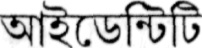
আইডেন্টিটি
